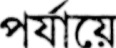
পর্যায়ে
